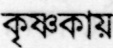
কৃষ্ণকায়
